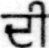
ਦੀ
